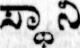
ಸ್ಥಾನಿ
